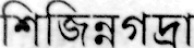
শিজিন্নগদ্রা
